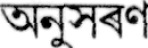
অনুসৰণ
